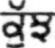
ਕੁੱਝ
